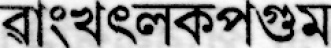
ৱাংখৎলকপগুম
